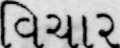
વિચાર
